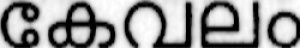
കേവലം
